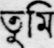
তুমি
